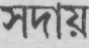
সদায়
